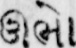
ઊભો
